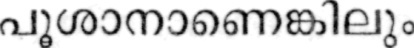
പൂശാനാണെങ്കിലും
